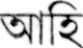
আহি
